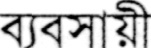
ব্যবসায়ী
